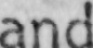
and
